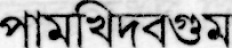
পামখিদবগুম
